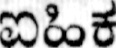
ಐಹಿಕ
